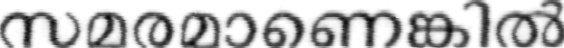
സമരമാണെങ്കില്‍
